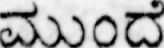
ಮುಂದೆ
